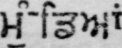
ਮੁੰਡਿਆਂ
